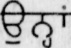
ਉਨ੍ਹਾਂ
